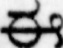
ಈ
